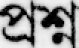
প্রশ্ন
